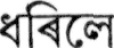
ধৰিলে
